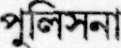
পুলিসনা
